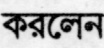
করলেন
